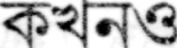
কখনও
